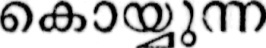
കൊയ്യുന്ന
